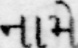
નામે
